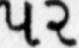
પર
